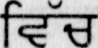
ਵਿੱਚ
